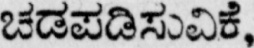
ಚಡಪಡಿಸುವಿಕೆ,
